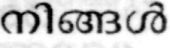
നിങ്ങള്‍
